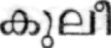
കുലീ
